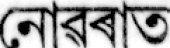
নোৱৰাত
